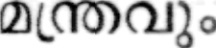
മന്ത്രവും
